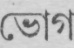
ভোগ
